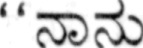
"ನಾನು
